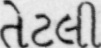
તેટલી
